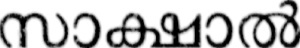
സാക്ഷാല്‍
